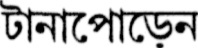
টানাপোড়েন
